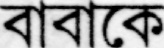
বাবাকে
